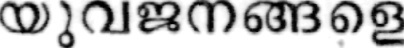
യുവജനങ്ങളെ
